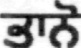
ਭਾਨੋ
